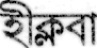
হীক্লবা
